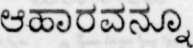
ಆಹಾರವನ್ನೂ
